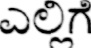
ಎಲ್ಲಿಗೆ
